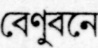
বেণুবনে
